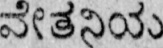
ವೇತನಿಯ
